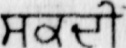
ਸਕਦੀ
